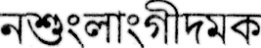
নশুংলাংগীদমক
